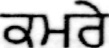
ਕਮਰੇ
